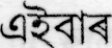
এইবাৰ
